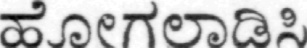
ಹೋಗಲಾಡಿಸಿ
